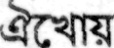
ঐখোয়
